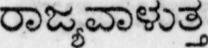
ರಾಜ್ಯವಾಳುತ್ತ
